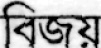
বিজয়
